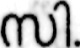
സി.
